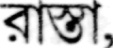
রাস্তা,
